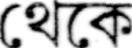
থেকে
